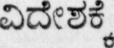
ವಿದೇಶಕ್ಕೆ
